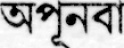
অপূনবা
